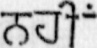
ਨਹੀਂ
